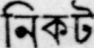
নিকট
